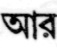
আর
